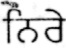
ਨਿਰੇ
